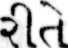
રીતે
